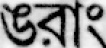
ঙরাং
